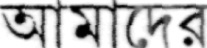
আমাদের
